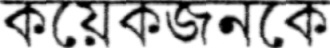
কয়েকজনকে
